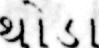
થોડા
